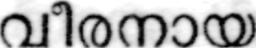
വീരനായ
